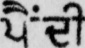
ਪੈਂਦੀ
